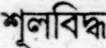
শূলবিদ্ধ
